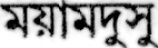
ময়ামদুসু
